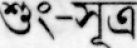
শুং-সূত্র
